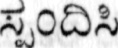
ಸ್ಪಂದಿಸಿ
